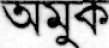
অমুক
